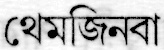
থেমজিনবা
